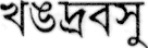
খঙদ্রবসু
